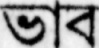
ভাব
